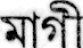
মাগী
